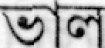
ভাল
